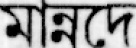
মান্নদে
